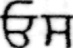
ਓਸ
